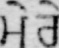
ਮੇਰੇ
